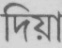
দিয়া
